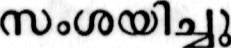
സംശയിച്ചു
